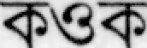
কওক
